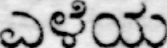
ಎಳೆಯ
